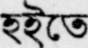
হইতে
